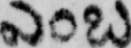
ಎಂಬ
